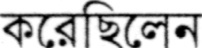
করেছিলেন
